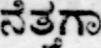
ನೆತ್ತಗಾ
